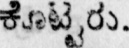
ಕೊಟ್ಟರು.
